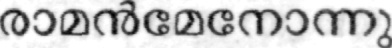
രാമന്‍മേനോന്നു
